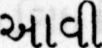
આવી
